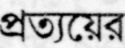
প্রত্যয়ের
